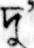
দু’
